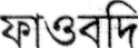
ফাওবদি
